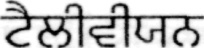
ਟੈਲੀਵੀਯਨ
